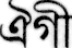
ঐগী
